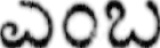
ಎಂಬ
